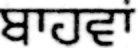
ਬਾਹਵਾਂ
